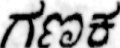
ಗಣಕ
